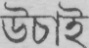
উচাই
